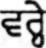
ਵਰ੍ਹੇ
